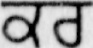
ਕਰ
